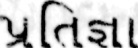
પ્રતિજ્ઞા
